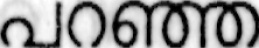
പറഞ്ഞ
